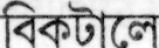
বিকটালে
